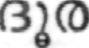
ദൂര
